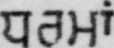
ਧਰਮਾਂ
